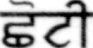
ਛੋਟੀ
